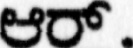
ಆರ್.
